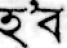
হ'ব
